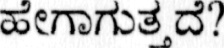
ಹೇಗಾಗುತ್ತದೆ?
